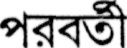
পরবর্তী
